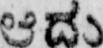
ಆದು
